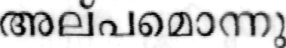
അല്പമൊന്നു
